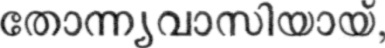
തോന്ന്യവാസിയായ്,
